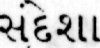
સંદેશા
